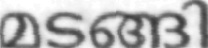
മടങ്ങി
